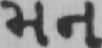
મન
